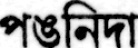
পঙনিদা
